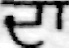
ਦਾ
